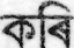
কৰি
